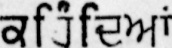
ਕਹਿੰਦਿਆਂ
